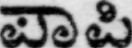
ಪಾಪಿ
